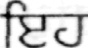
ਇਹ
